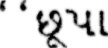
"છૂપા
